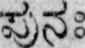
ಪುನಃ
